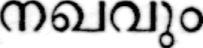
നഖവും
